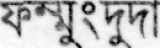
ফম্মুংদুদা
